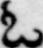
ಓ
